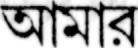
আমার
